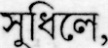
সুধিলে,
